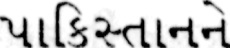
પાકિસ્તાનને
